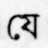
যে
